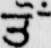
ਤੋਂ
